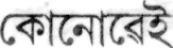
কোনোৱেই
